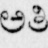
ಅತಿ
